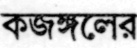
কজঙ্গলের
